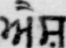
ਐਸ਼
